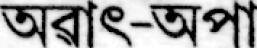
অৱাৎ-অপা
